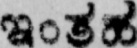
ಇಂತಹ
